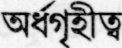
অর্ধগৃহীত্ব
